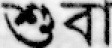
শুবা
